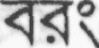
বরং
